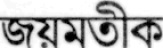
জয়মতীক
